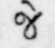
જે
